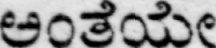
ಅಂತೆಯೇ
